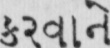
કરવાને
